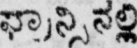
ಫ್ರಾನ್ಸಿನಲ್ಲಿ
